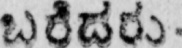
ಬರೆದರು.
